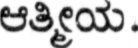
ಆತ್ಮೀಯ.
